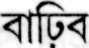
বাঢ়িব
